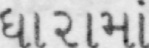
ધારામાં
